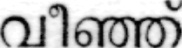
വീഞ്ഞ്
